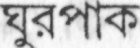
ঘুরপাক
